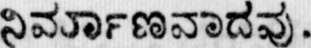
ನಿರ್ಮಾಣವಾದವು.
